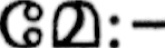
മേ:-
